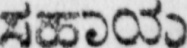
ಸಹಾಯ
